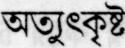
অত্যুত্কৃষ্ট
